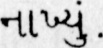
નાખ્યું.
